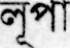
লূপা
